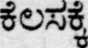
ಕೆಲಸಕ್ಕೆ
